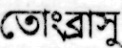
তোংব্রাসু
